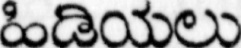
ಹಿಡಿಯಲು
